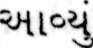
આવ્યું
